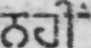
ਨਹੀਂ
